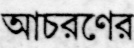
আচরণের
